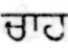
ਚਾਹ
